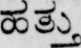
ಹತ್ತು
